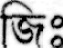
জিঃ
